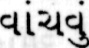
વાંચવું
